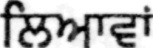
ਲਿਆਵਾਂ
